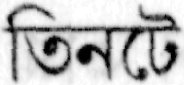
তিনটে
